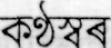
কণ্ঠস্বৰ
